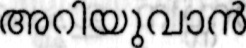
അറിയുവാന്‍
